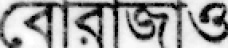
বোরাজাও
